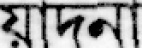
য়াদনা
